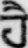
ਹੈ
